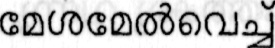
മേശമേല്‍വെച്ച്
